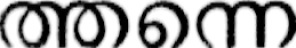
ത്തന്നെ
